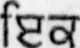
ਇਕ
